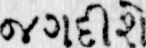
જગદીશે
